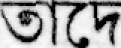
তাদে
